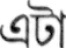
এটা
